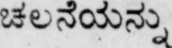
ಚಲನೆಯನ್ನು
